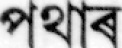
পথাৰ
